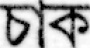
চাক
